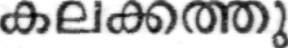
കലക്കത്തു
